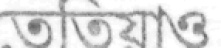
তেতিয়াও
